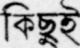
কিছুই
